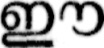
ഈ
